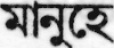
মানুহে
